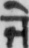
ਜੇ
